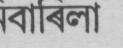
নবাৰিলা
